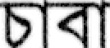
চাবা
